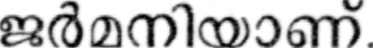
ജര്‍മനിയാണ്.
